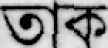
তাক
